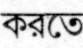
করতে
